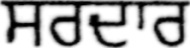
ਸਰਦਾਰ
